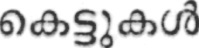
കെട്ടുകള്‍
